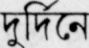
দুর্দিনে
